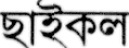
ছাইকল
